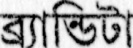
ব্র্যান্ডিটা
